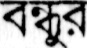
বন্ধুর
